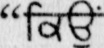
''ਕਿਉਂ
